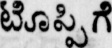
ಟೊಪ್ಪಿಗೆ
